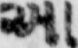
આ
